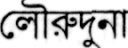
লৌরুদুনা
